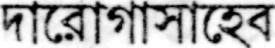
দারোগাসাহেব
